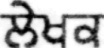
ਲੇਖਕ
